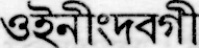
ওইনীংদবগী
